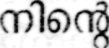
നിന്റെ
